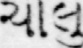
ચાલુ
